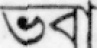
ভবা
